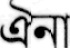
ঐনা
